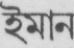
ইমান
